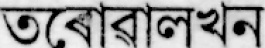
তৰোৱালখন
